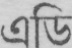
এড়ি
